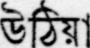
উঠিয়া
